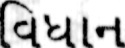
વિધાન
